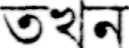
তখন
